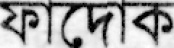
ফাদোক
